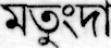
মতুংদা
